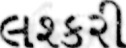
લશ્કરી
